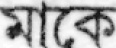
মাকে
